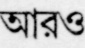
আরও
